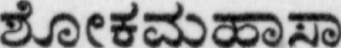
ಶೋಕಮಹಾಸಾ
